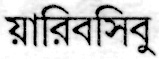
য়ারিবসিবু
